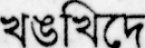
খঙখিদে
